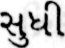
સુધી
